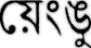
য়েংঙু
